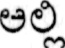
ಅಲ್ಲಿ
